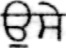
ਉਸੇ
